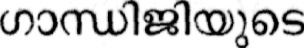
ഗാന്ധിജിയുടെ
